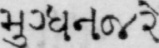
મુગ્ધનજરે
